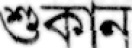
শুকান
